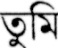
তুমি
